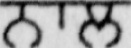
ਨਾਲ
